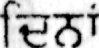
ਦਿਨਾਂ
